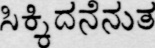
ಸಿಕ್ಕಿದನೆನುತ
